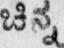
ಚಿನ್ನ
